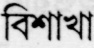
বিশাখা
